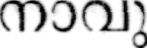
നാവു
